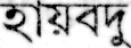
হায়বদুল
